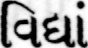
વિદ્યાં
